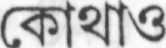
কোথাও
